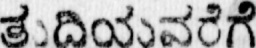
ತುದಿಯವರೆಗೆ
